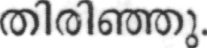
തിരിഞ്ഞു.
